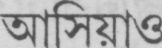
আসিয়াও
